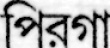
পিরগা
